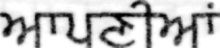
ਆਪਣੀਆਂ
